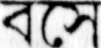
বসে
